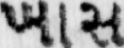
ખાસ
